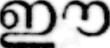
ഈ
